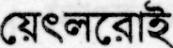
য়েৎলরোই
